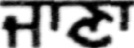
ਜਾਣਾ
